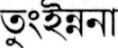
তুংইন্ননা
